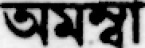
অমম্বা
